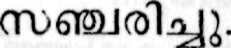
സഞ്ചരിച്ചു.
